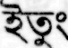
ইতুং
